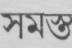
সমস্ত
